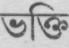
ভক্তি
